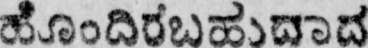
ಹೊಂದಿರಬಹುದಾದ
